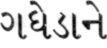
ગધેડાને
